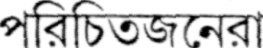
পরিচিতজনেরা
